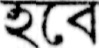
হবে
